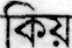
কিয়
